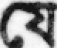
যে
